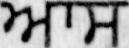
ਆਸ
